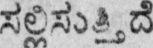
ಸಲ್ಲಿಸುತ್ತಿದೆ
